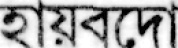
হায়বদো
